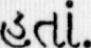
હતાં.
